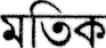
মতিক
